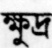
ক্ষুদ্র
